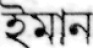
ইমান
